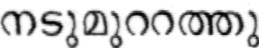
നടുമുററത്തു
